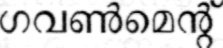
ഗവണ്‍മെന്റ്
